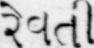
રેવતી
